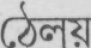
ঠেলয়
